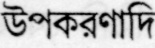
উপকরণাদি
